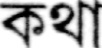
কথা
